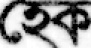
হেক
